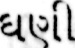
ઘણી
